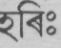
হৰিঃ
